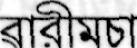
ৱারীমচা
